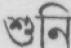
শুনি
